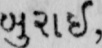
બુરાઈ,
